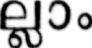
ല്ലാം
